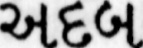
અદબ
